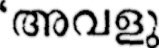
‘അവളു
